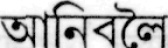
আনিবলৈ
